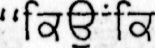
''ਕਿਉਂਕਿ
